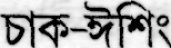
চাক-ঈশিং
